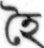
হৈ
